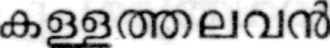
കള്ളത്തലവന്‍
